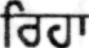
ਰਿਹਾ
